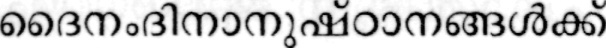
ദൈനംദിനാനുഷ്ഠാനങ്ങള്‍ക്ക്
